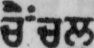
ਚੈਂਚਲ
